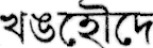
খঙহৌদে
